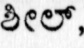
ಶೀಲ್,
